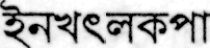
ইনখৎলকপা
